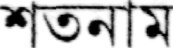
শতনাম
